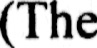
(The
